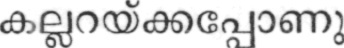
കല്ലറയ്ക്കപ്പോണു
